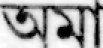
অমা
